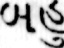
બહુ
